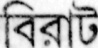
বিরাট
